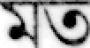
মত
